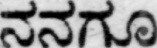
ನನಗೂ
